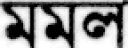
মমল
